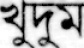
খুদুম
